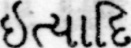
ઈત્યાદિ
